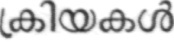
ക്രിയകള്‍
